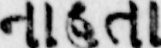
નાહતા
